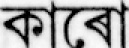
কাৰো
